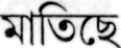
মাতিছে
